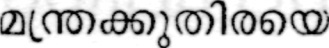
മന്ത്രക്കുതിരയെ
